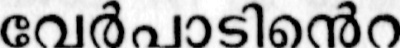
വേര്‍പാടിന്റെ
